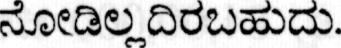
ನೋಡಿಲ್ಲದಿರಬಹುದು.
